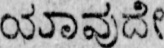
ಯಾವುದೇ
